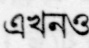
এখনও
